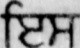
ਇਸ
